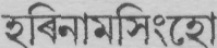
হৰিনামসিংহো
